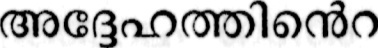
അദ്ദേഹത്തിന്റെ
